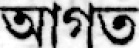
আগত
